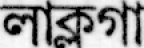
লাক্লগা
